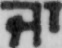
ਜਾ
